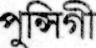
পুন্সিগী
